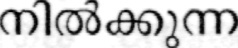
നില്‍ക്കുന്ന
